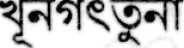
খূনগৎতুনা
